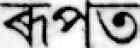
ৰূপত
